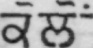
ਕੋਲੋਂ
